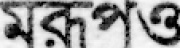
মরূপও
